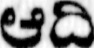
ಆದಿ
